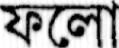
ফলো
